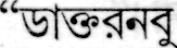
ডাক্তরনবু
